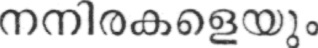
നനിരകളെയും
